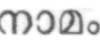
നാമം
